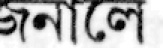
জনালে
